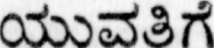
ಯುವತಿಗೆ
